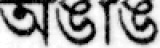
অঙাঙ
